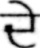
ਦੇ
